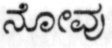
ನೋವು
